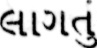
લાગતું
